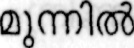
മുന്നില്‍
